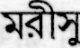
মরীসু
